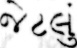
જેટલું
